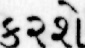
કરશે
